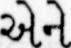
એને
